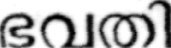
ഭവതി
